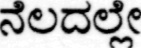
ನೆಲದಲ್ಲೇ
